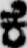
ಕೆ
